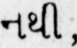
નથી,
